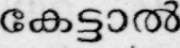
കേട്ടാല്‍
